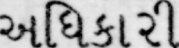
અધિકારી
